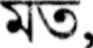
মত,
